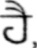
ਹੈ,
